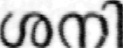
ശനി
